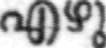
എഴു
